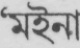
'মইনা
